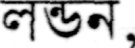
লন্ডন,
